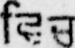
ਵਿਚ
